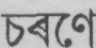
চৰণে
